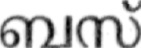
ബസ്
